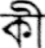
কী
